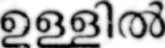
ഉള്ളില്‍
